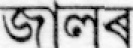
জালৰ
